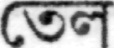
তেল
